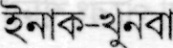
ইনাক-খুনবা
